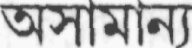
অসামান্য
